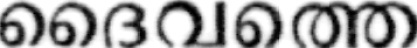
ദൈവത്തെ
